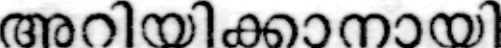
അറിയിക്കാനായി
